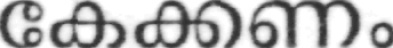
കേക്കണം
